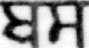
ਬਸ
